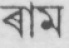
ৰাম
